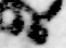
જે
